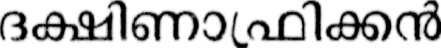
ദക്ഷിണാഫ്രിക്കന്‍
